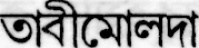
তাবীমোলদা
